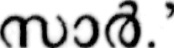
സാര്‍.’
